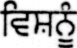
ਵਿਸ਼ਨੂੰ
